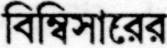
বিম্বিসারের
